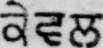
ਕੇਵਲ
